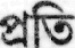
প্ৰতি
